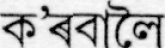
ক'ৰবালৈ
